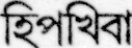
হিপখিবা
